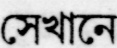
সেখানে
